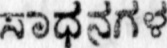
ಸಾಧನಗಳ
